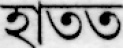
হাতত
